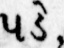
પડે,
